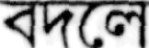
বদলে
